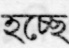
হচ্ছে
